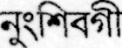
নুংশিবগী
